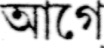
আগে
